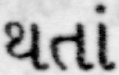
થતાં
